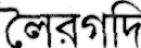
লৈরগদি
